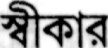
স্বীকার
